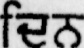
ਦਿਨ
